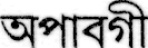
অপাবগী
